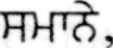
ਸਮਾਨੇ,
